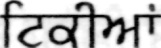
ਟਿਕੀਆਂ
